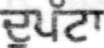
ਦੁਪੱਟਾ
